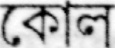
কোল
